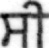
ਸੀ
